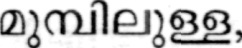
മുമ്പിലുള്ള,
